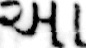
આ
